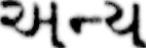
અન્ય
